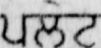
ਪਲੇਟ
